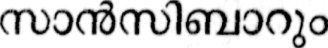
സാന്‍സിബാറും
